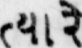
ત્યારે
